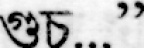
গুচ..."
